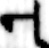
ન
